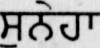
ਸੁਨੇਹਾ
